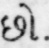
છો.
